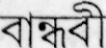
বান্ধবী
